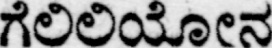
ಗೆಲಿಲಿಯೋನ
